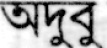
অদুবু
